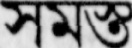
সমস্ত
